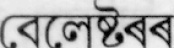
বেলেষ্টৰৰ
